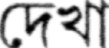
দেখা
